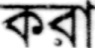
করা
